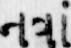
નવાં
